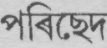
পৰিছেদ
